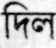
দিল
